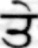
ਤੇ
